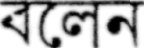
বলেন
